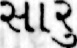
સારુ
